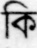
কি
